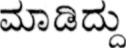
ಮಾಡಿದ್ದು
